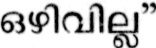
ഒഴിവില്ല”
